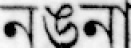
নঙনা
